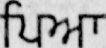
ਪਿਆ
